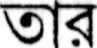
তার
